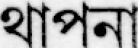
থাপনা
